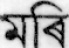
মৰি
